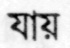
যায়
